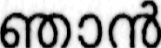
ഞാന്‍
